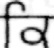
ਕਿ
